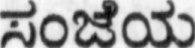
ಸಂಜೆಯ
